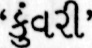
'કુંવરી'
